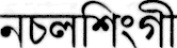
নচলশিংগী
